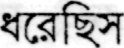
ধরেছিস
